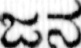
ಜನ
